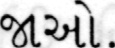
જાઓ.
